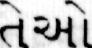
તેઓ
